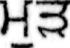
ਮੁੜ
